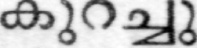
കുറച്ചു
